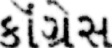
કૉંગ્રેસ
